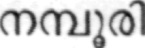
നമ്പൂരി
